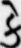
કે
